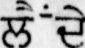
ਲੈਂਦੇ
